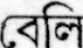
বেলি
